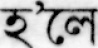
হ'লে
